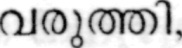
വരുത്തി,
